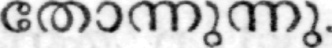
തോന്നുന്നു.
